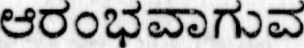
ಆರಂಭವಾಗುವ
